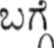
ಬಗ್ಗೆ
